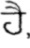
ਹੈ,
